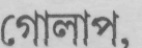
গোলাপ,
